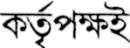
কর্তৃপক্ষই
